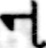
ન
